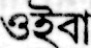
ওইবা
